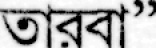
তারবা”
